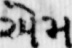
એમ
